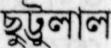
ছুট্টুলাল
